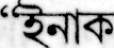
“ইনাক
